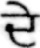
ਦੇ
